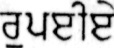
ਰੁਪਈਏ
